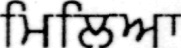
ਮਿਲਿਆ
